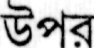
উপর
